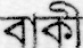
বাকী
